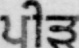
ਪੀੜ
